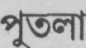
পুতলা
